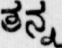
ತನ್ನ
